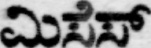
ಮಿಸೆಸ್
